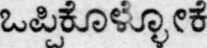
ಒಪ್ಪಿಕೊಳ್ಳೋಕೆ
